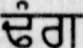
ਢੰਗ
